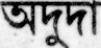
অদুদা
